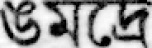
ঙমদ্রে
